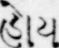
હોય
